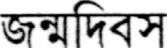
জন্মদিবস
